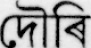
দৌৰি
